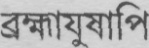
ব্ৰহ্মাযুষাপি
